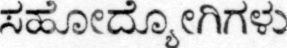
ಸಹೋದ್ಯೋಗಿಗಳು
